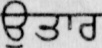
ਉਤਾਰ
